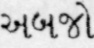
અબજો
